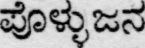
ಪೊಳ್ಳುಜನ
